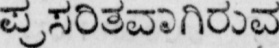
ಪ್ರಸರಿತವಾಗಿರುವ
